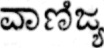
ವಾಣಿಜ್ಯ
